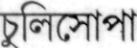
চুলিসোপা
